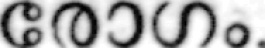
രോഗം.
